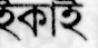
ইকাই
